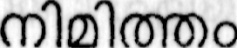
നിമിത്തം
